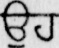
ਉਹ
